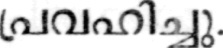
പ്രവഹിച്ചു.
